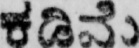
ಕಡಿಮೆ
